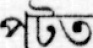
পটত
